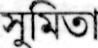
সুমিতা
